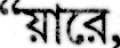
“য়ারে,
